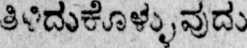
ತಿಳಿದುಕೊಳ್ಳುವುದು
